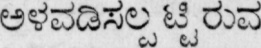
ಅಳವಡಿಸಲ್ಪಟ್ಟಿರುವ
